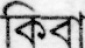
কিবা
